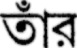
তাঁর
